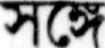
সঙ্গে
